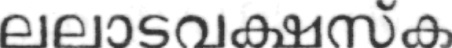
ലലാടവക്ഷസ്ക
